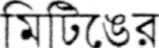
মিটিঙের
